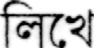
লিখে
